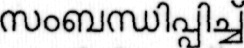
സംബന്ധിപ്പിച്ച്
